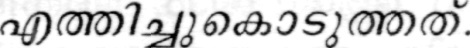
എത്തിച്ചുകൊടുത്തത്.
